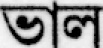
ভাল
